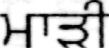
ਮਾੜੀ
